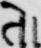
તો
